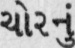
ચોરનું
